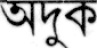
অদুক
